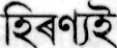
হিৰণ্যই
